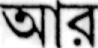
আর
